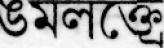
ঙমলক্ত্রে
